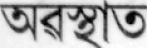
অৱস্থাত
